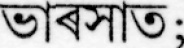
ভাৰসাত;
